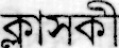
ক্লাসকী
